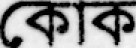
কোক
